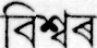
বিশ্বৰ
